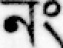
নং
